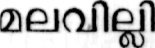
മലവില്ലി
